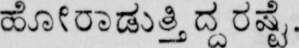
ಹೋರಾಡುತ್ತಿದ್ದರಷ್ಟೆ.
